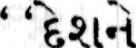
"દેશને
